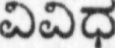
ವಿವಿಧ
